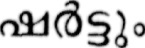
ഷര്‍ട്ടും
